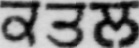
ਕਤਲ
